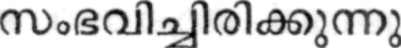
സംഭവിച്ചിരിക്കുന്നു
